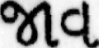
જાવ
